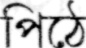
পিঠে
